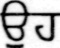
ਉਹ
